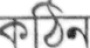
কঠিন
